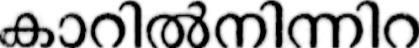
കാറില്‍നിന്നിറ
